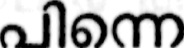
പിന്നെ
